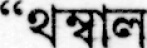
“থম্বাল
